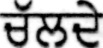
ਚੱਲਦੇ
